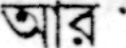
আর
